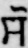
ਸੋ
